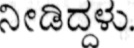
ನೀಡಿದ್ದಳು.
